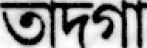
তাদগা
